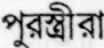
পুরস্ত্রীরা
